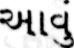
આવું
